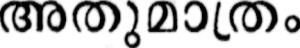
അതുമാത്രം
